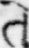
તે
